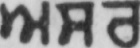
ਅਸਰ
